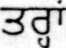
ਤਰ੍ਹਾਂ
